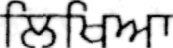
ਲਿਖਿਆ
